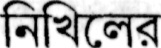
নিখিলের
